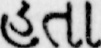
હતા
